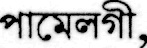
পামেলগী,
